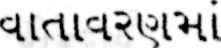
વાતાવરણમાં
